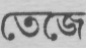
তেজে
